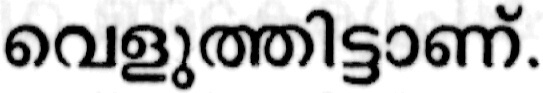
വെളുത്തിട്ടാണ്.
